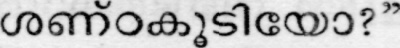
ശണ്ഠകൂടിയോ?”
